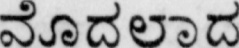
ಮೊದಲಾದ
